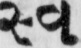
સ્વ
